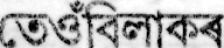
তেওঁবিলাকৰ
